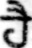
ਹੈ
